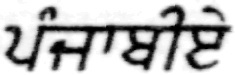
ਪੰਜਾਬੀਏ
